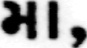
મા,
